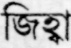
জিহ্বা
